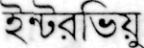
ইন্টরভিয়ু
